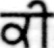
ਕੀ
